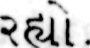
રહ્યો.
